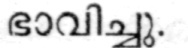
ഭാവിച്ചു.
